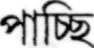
পাচ্ছি
